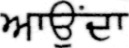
ਆਉਂਦਾ
